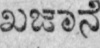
ಖಜಾನೆ
